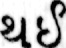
થઈ
